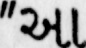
"આ
